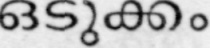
ഒടുക്കം
